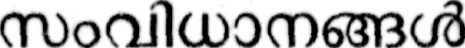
സംവിധാനങ്ങള്‍
